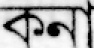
কনা
